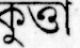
কুত্তা
